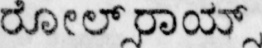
ರೋಲ್ಸ್ರಾಯ್ಸ್
